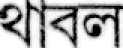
থাবল
